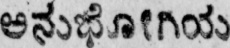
ಅನುಭೋಗಿಯ
